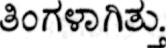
ತಿಂಗಳಾಗಿತ್ತು.
